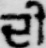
ਦੀ
